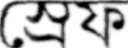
স্রেফ
